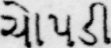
ચોપડી
